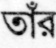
তাঁর
